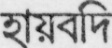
হায়বদি
